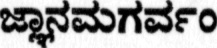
ಜ್ಞಾನಮಗರ್ವಂ
